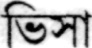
ভিসা
